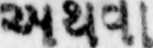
અથવા
